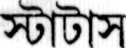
স্টাটাস
